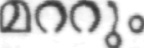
മററും
